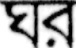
ঘর
